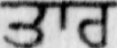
ਤਾਰ
